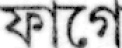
ফাগে
